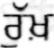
ਰੁੱਖ਼
